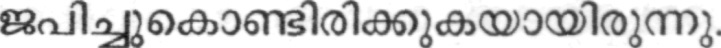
ജപിച്ചുകൊണ്ടിരിക്കുകയായിരുന്നു.
